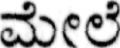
ಮೇಲೆ
